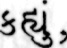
કહ્યું,
